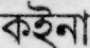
কইনা
